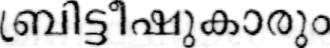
ബ്രിട്ടീഷുകാരും
